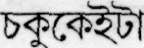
চকুকেইটা
